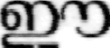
ഈ
